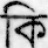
কি
